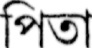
পিতা
